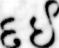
દઈ
